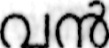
വന്‍
